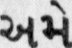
અમે
